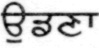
ਉਡਣਾ
